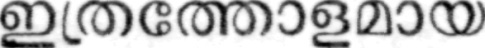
ഇത്രത്തോളമായ
